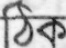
ঠিক
